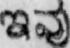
ಇವು
